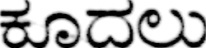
ಕೂದಲು
